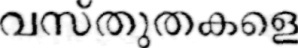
വസ്തുതകളെ
